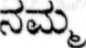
ನಮ್ಮ
